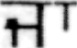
ਜਾ
